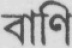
বাণি
